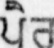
ਪੈਰ
